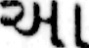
આ
